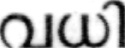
വധി
